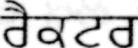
ਰੈਕਟਰ
